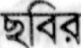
ছবির
